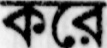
করে
